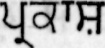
ਪ੍ਰਕਾਸ਼
